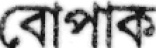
বোপাক
